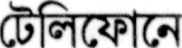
টেলিফোনে
